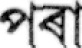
পৰা
